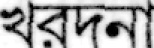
খরদনা
